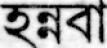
হন্নবা
